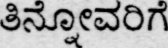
ತಿನ್ನೋವರಿಗೆ
